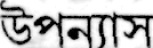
উপন্যাস
